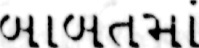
બાબતમાં
